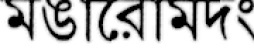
মঙারোমদং
